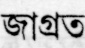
জাগ্রত
